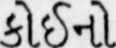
કોઈનો
